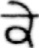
ਕੇ
